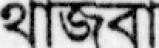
থাজবা
